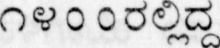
೧೪೦೦ರಲ್ಲಿದ್ದ
